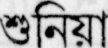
শুনিয়া
